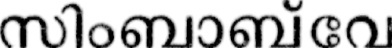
സിംബാബ്വേ
